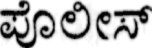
ಪೊಲೀಸ್
